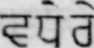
ਵਧੇਰੇ
